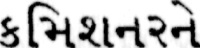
કમિશનરને
